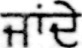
ਜਾਂਦੇ
